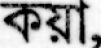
কয়া,
